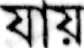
যায়
